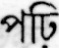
পঢ়ি
